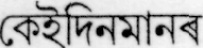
কেইদিনমানৰ
